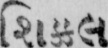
શિક્કલ
